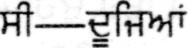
ਸੀ-ਦੂਜਿਆਂ
